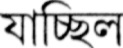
যাচ্ছিল
